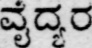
ವೈದ್ಯರ
